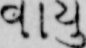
વાયુ
